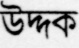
উদ্দক
